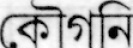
কৌগনি
